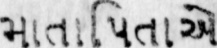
માતાપિતાએ
